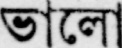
ভালো
